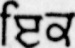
ਇਕ
